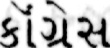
કૉંગ્રેસ
